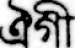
ঐগী
